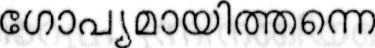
ഗോപ്യമായിത്തന്നെ
